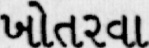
ખોતરવા
